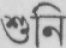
শুনি
